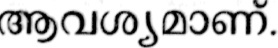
ആവശ്യമാണ്.
